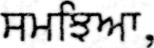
ਸਮਝਿਆ,
